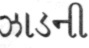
ઝાડની
